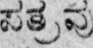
ಪತ್ರವು
